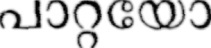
പാറ്റയോ
